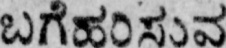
ಬಗೆಹರಿಸುವ
